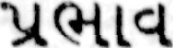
પ્રભાવ
